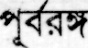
পুর্বরঙ্গ
